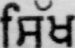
ਸਿੱਖ
